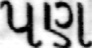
પણ
